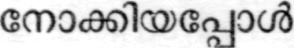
നോക്കിയപ്പോള്‍
